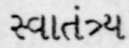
સ્વાતંત્ર્ય
